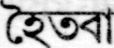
হৈতবা
